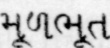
મૂળભૂત
